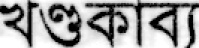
খণ্ডকাব্য
